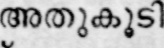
അതുകൂടി
